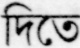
দিতে
